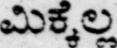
ಮಿಕ್ಕೆಲ್ಲ
